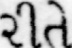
રીતે
